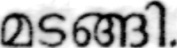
മടങ്ങി.
